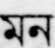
মন
